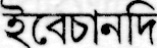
ইবেচানদি
